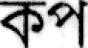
কপ
